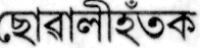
ছোৱালীহঁতক
